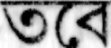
তবে
